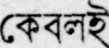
কেবলই
